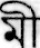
মী
